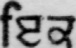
ਇਕ
